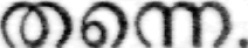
തന്നെ.
